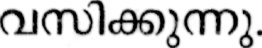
വസിക്കുന്നു.
